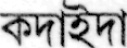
কদাইদা
